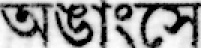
অঙাংসে
